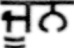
ਜੂਨ
